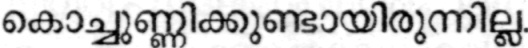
കൊച്ചുണ്ണിക്കുണ്ടായിരുന്നില്ല.
